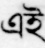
এই
